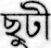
ছুটী
